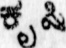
ಕೃಷಿ
